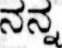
ನನ್ನ
